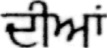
ਦੀਆਂ
